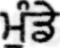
ਮੁੰਡੇ
